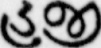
હજી
